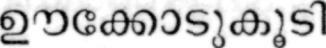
ഊക്കോടുകൂടി
